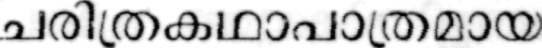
ചരിത്രകഥാപാത്രമായ
